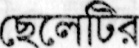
ছেলেটির
